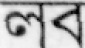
লব
